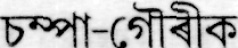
চম্পা-গৌৰীক
